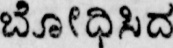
ಬೋಧಿಸಿದ
